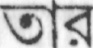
তার
